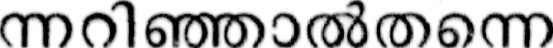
ന്നറിഞ്ഞാല്‍തന്നെ
